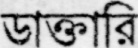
ডাক্তারি
